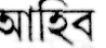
আহিব
